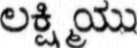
ಲಕ್ಷ್ಮಿಯು
